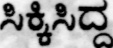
ಸಿಕ್ಕಿಸಿದ್ದ
